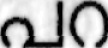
പറ
